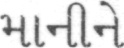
માનીને
